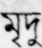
মৃদু
